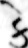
કે
